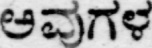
ಅವುಗಳ
